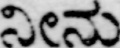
ನೀನು
